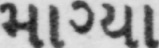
માગ્યા
